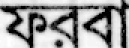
ফরবা
